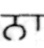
ਨਾ
